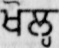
ਖੋਲ੍ਹ
